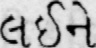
લઈને
